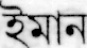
ইমান
